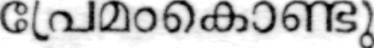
പ്രേമംകൊണ്ടു
